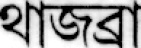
থাজব্রা
